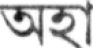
অহা
